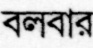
বলবার
